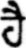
ਹੈ
